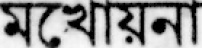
মখোয়না
